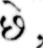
છે.
